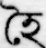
হৈ
